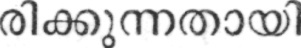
രിക്കുന്നതായി
